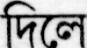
দিলে
